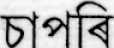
চাপৰি
